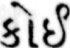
કોઈ
